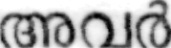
അവര്‍
